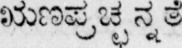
ಋಣಪ್ರಚ್ಛನ್ನತೆ
